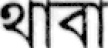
থাবা
